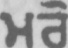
ਮਰੋ
